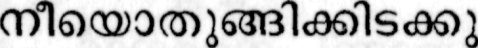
നീയൊതുങ്ങിക്കിടക്കു
